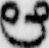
ಆ
